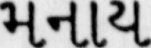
મનાય
